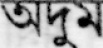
অদুম
